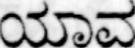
ಯಾವ
